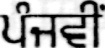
ਪੰਜਵੀਂ
